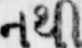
નથી
